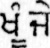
ਖੂੰਜੇ
